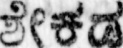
ಶೇಕಡ
